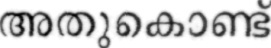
അതുകൊണ്ട്
